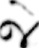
જે
